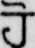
ਹੋ
